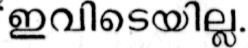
‘ഇവിടെയില്ല.
